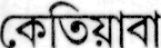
কেতিয়াবা
